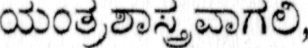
ಯಂತ್ರಶಾಸ್ತ್ರವಾಗಲಿ,
